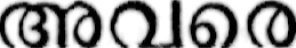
അവരെ
